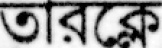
তারক্লে
